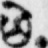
છે.
